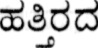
ಹತ್ತಿರದ
